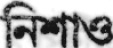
নিশাও
